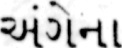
અંગેના
